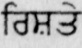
ਰਿਸ਼ਤੇ
